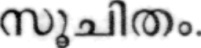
സൂചിതം.
